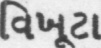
વિખૂટા
